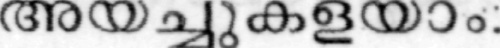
അയച്ചുകളയാം.
